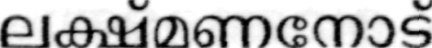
ലക്ഷ്മണനോട്
